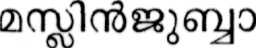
മസ്ലിന്‍ജുബ്ബാ
